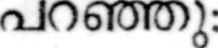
പറഞ്ഞു:
